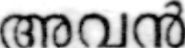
അവന്‍
